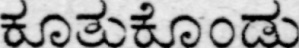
ಕೂತುಕೊಂಡು
